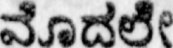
ಮೊದಲೇ
